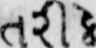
તરીકે
